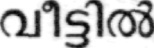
വീട്ടില്‍
